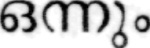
ഒന്നും
